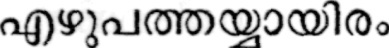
എഴുപത്തയ്യായിരം
